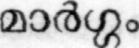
മാര്‍ഗ്ഗം
